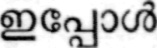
ഇപ്പോള്‍
